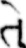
તે
